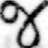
જ
